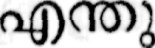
എന്തു
